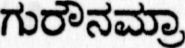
ಗುರೌನಮ್ರಾ
